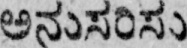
ಅನುಸರಿಸು
